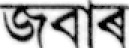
জবাৰ
